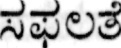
ಸಫಲತೆ
